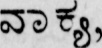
ವಾಕ್ಯ,
